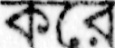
করে
